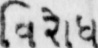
વિરોધ
